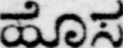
ಹೊಸ
